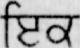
ਇਕ
